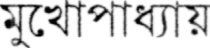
মুখোপাধ্যায়
